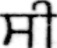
ਸੀ
